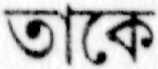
তাকে
